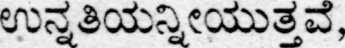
ಉನ್ನತಿಯನ್ನೀಯುತ್ತವೆ,
